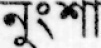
নুংশা
